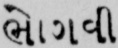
ભોગવી
